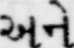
અને
